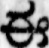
ಈ
